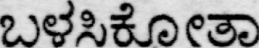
ಬಳಸಿಕೋತಾ
